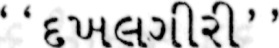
"દખલગીરી"
